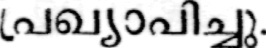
പ്രഖ്യാപിച്ചു.
